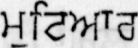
ਮੁਟਿਆਰ
